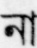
না
